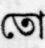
তো
